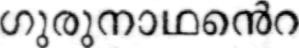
ഗുരുനാഥന്റെ
